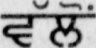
ਵੱਲੋਂ
